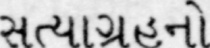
સત્યાગ્રહનો
